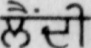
ਲੈਂਦੀ
